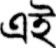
এই
